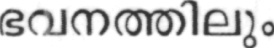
ഭവനത്തിലും
